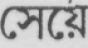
সেয়ে
